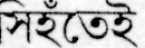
সিহঁতেই
